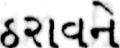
ઠરાવને
